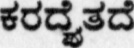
ಕರದ್ವೈತದೆ
